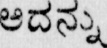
ಅದನ್ನು
